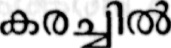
കരച്ചില്‍
